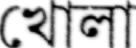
খোলা
